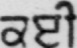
ਕਈ
